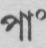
পা
